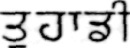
ਤੁਹਾਡੀ
